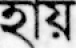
হায়
